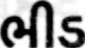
ભીડ
